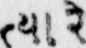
ત્યારે
